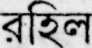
রহিল
